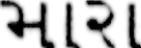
મારા
